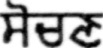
ਸੋਚਣ
